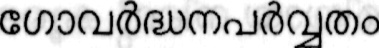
ഗോവര്‍ദ്ധനപര്‍വ്വതം
